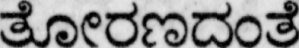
ತೋರಣದಂತೆ
